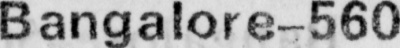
Bangalore-560
